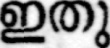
ഇതു
